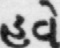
હવે
